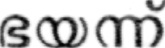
ഭയന്ന്
